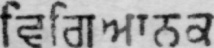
ਵਿਗਿਆਨਕ
